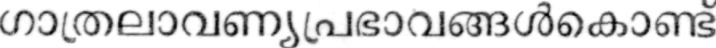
ഗാത്രലാവണ്യപ്രഭാവങ്ങള്‍കൊണ്ട്
